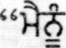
''ਮੈਨੂੰ
